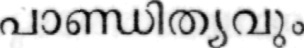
പാണ്ഡിത്യവും
